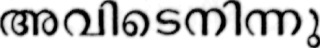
അവിടെനിന്നു
